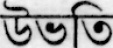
উভতি
